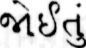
જોઈતું
